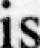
is
